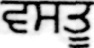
ਵਸਤੂ
